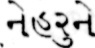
નેહરુને
